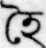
হৈ
